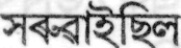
সৰুৱাইছিল
